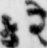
કરે
